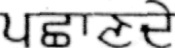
ਪਛਾਣਦੇ
